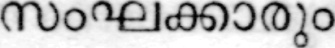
സംഘക്കാരും
